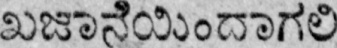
ಖಜಾನೆಯಿಂದಾಗಲಿ
